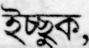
ইচ্ছুক,
